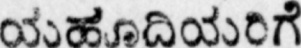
ಯಹೂದಿಯರಿಗೆ
